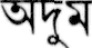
অদুম
